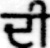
ਦੀ
